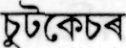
চুটকেচৰ
